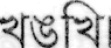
খঙখি।
